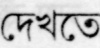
দেখতে
